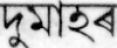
দুমাহৰ
